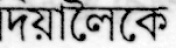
দিয়ালৈকে
